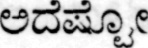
ಅದೆಷ್ಟೋ
